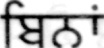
ਬਿਨਾਂ
